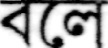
বলে
